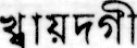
খ্বায়দগী
